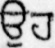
ਉਹ
